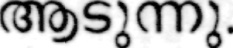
ആടുന്നു.
